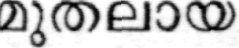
മുതലായ
